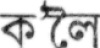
ক'লৈ
